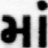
માં
